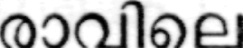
രാവിലെ
